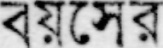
বয়সের
